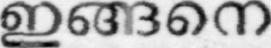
ഇങ്ങനെ
